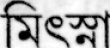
মিৎস্না
